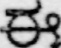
ಈ
